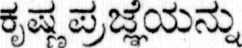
ಕೃಷ್ಣಪ್ರಜ್ಞೆಯನ್ನು
